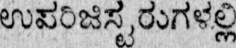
ಉಪರಿಜಿಸ್ಟರುಗಳಲ್ಲಿ
